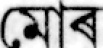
মোৰ
